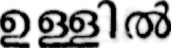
ഉള്ളില്‍
